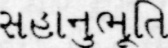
સહાનુભૂતિ
